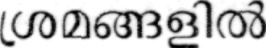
ശ്രമങ്ങളില്‍
